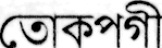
তোকপগী
